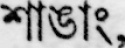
শাঙাং,
